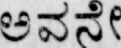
ಅವನೇ
